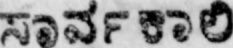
ಸಾರ್ವಕಾಲಿ
